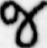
જ
